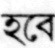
হবে
